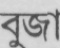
বুজা
